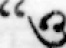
“ও
